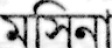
মসিনা
